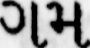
ગમ
